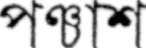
পঞ্চাশ
